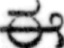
ಈ
